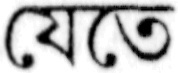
যেতে
